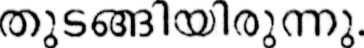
തുടങ്ങിയിരുന്നു.
